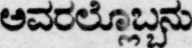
ಅವರಲ್ಲೊಬ್ಬನು
